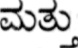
ಮತ್ತು
